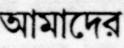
আমাদের
